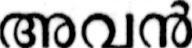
അവന്‍
